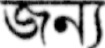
জন্য
